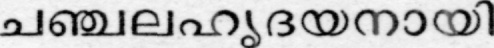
ചഞ്ചലഹൃദയനായി
